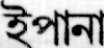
ইপানা
